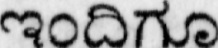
ಇಂದಿಗೂ
